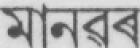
মানৱৰ
